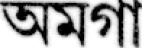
অমগা
